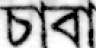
চাবা
